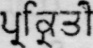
ਪ੍ਰਕ੍ਰਿਤੀ
